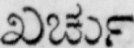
ಖರ್ಚು
